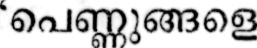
‘പെണ്ണുങ്ങളെ
